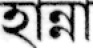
হান্না
